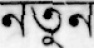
নতুন
